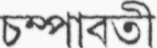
চম্পাবতী
